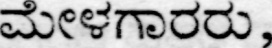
ಮೇಳಗಾರರು,
